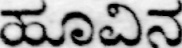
ಹೂವಿನ
